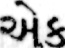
એક
